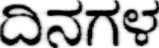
ದಿನಗಳ
